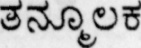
ತನ್ಮೂಲಕ
